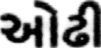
ઓઢી
